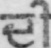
ਦੀ
